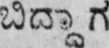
ಬಿದ್ದಾಗ
